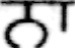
ਨਾ
